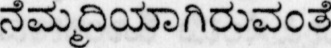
ನೆಮ್ಮದಿಯಾಗಿರುವಂತೆ
